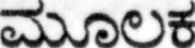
ಮೂಲಕ
